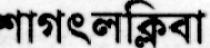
শাগৎলক্লিবা
